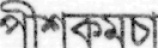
পীশকমচা
